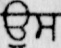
ਉਸ
